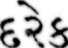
દરેક
